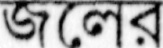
জলের
